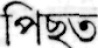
পিছত
